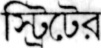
স্ট্রিটের
